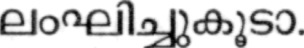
ലംഘിച്ചുകൂടാ.
